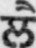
ਲੈ
